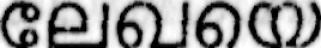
ലേഖയെ
